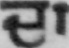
ਦਾ
